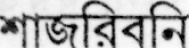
শাজরিবনি
